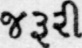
જરૂરી
